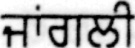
ਜਾਂਗਲੀ
